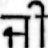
ਜੀ
